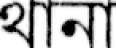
থানা
